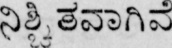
ನಿಶ್ಚಿತವಾಗಿವೆ
